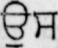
ਉਸ
